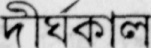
দীর্ঘকাল
